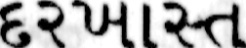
દરખાસ્ત
